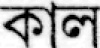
কাল
